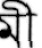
মী
